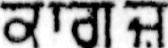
ਕਾਗਜ਼
